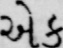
એક
